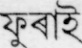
ফুৰাই
